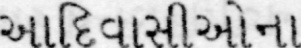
આદિવાસીઓના
